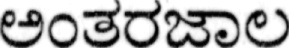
ಅಂತರಜಾಲ
